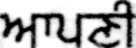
ਆਪਣੀ
